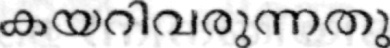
കയറിവരുന്നതു
